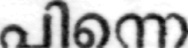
പിന്നെ
